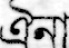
ঐনা
